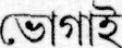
ভোগাই
